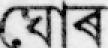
ঘোৰ
